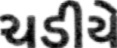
ચડીયે
